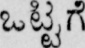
ಒಟ್ಟಿಗೆ
